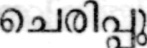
ചെരിപ്പു
